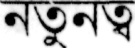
নতুনত্ব
